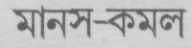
মানস-কমল
